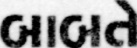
બાબતે
